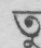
তু
